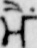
ਮੈਂ
